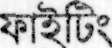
ফাইটিং
